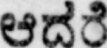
ಆದರೆ
